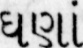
ઘણાં
